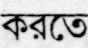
করতে
